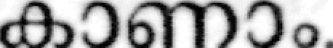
കാണാം.
